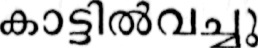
കാട്ടില്‍വച്ചു
